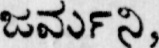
ಜರ್ಮನಿ,
